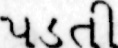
પડતી
